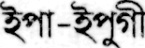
ইপা-ইপুগী
